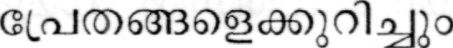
പ്രേതങ്ങളെക്കുറിച്ചും
